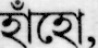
হাঁহো,
